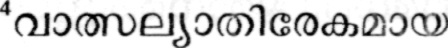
4വാത്സല്യാതിരേകമായ
